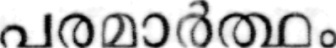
പരമാര്‍ത്ഥം
